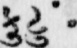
કુટું
